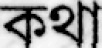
কথা
